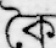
কৈ
